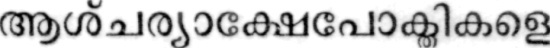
ആശ്ചര്യാക്ഷേപോക്തികളെ
